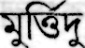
মুর্ত্তিদু
